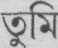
তুমি
